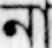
না
